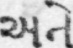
અને
